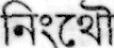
নিংথৌ
